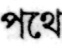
পথে
